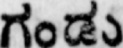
ಗಂಡು
